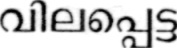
വിലപ്പെട്ട
